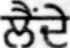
ਲੈਂਦੇ
